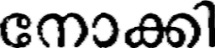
നോക്കി
